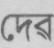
দেৱ
